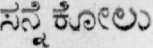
ಸನ್ನೆಕೋಲು
